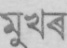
মুখৰ
